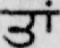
ਤਾਂ
